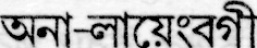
অনা-লায়েংবগী
